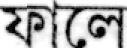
ফালে
